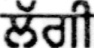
ਲੱਗੀ''
